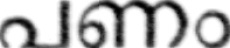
പണം
